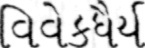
વિવેકધૈર્ય
